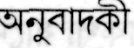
অনুবাদকী
